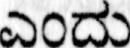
ಎಂದು
